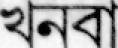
খনবা
